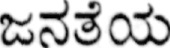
ಜನತೆಯ
